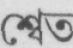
শ্বেত
